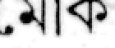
মোক
